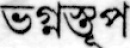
ভগ্নস্তূপ
